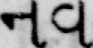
નવ
